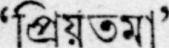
‘প্রিয়তমা’
